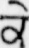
ਕੇ
